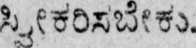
ಸ್ವೀಕರಿಸಬೇಕು.
